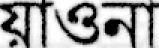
য়াওনা
